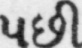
પછી
